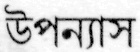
উপন্যাস
